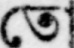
তো
